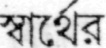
স্বার্থের
